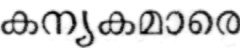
കന്യകമാരെ
